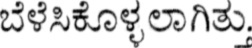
ಬೆಳೆಸಿಕೊಳ್ಳಲಾಗಿತ್ತು.
